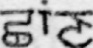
ਛਾਂਣ
